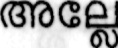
അല്ലേ
